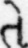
તે
